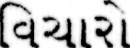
વિચારો
